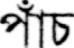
পাঁচ
